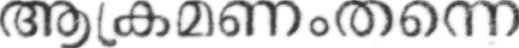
ആക്രമണംതന്നെ
